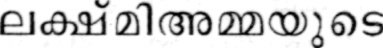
ലക്ഷ്മിഅമ്മയുടെ
